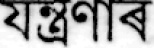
যন্ত্ৰণাৰ
